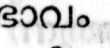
ഭാവം
